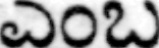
ಎಂಬ
